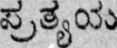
ಪ್ರತ್ಯಯ
